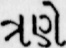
ત્રણે
